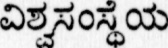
ವಿಶ್ವಸಂಸ್ಥೆಯ
